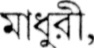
মাধুরী,
